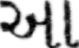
આ
